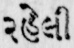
રહેલી
